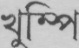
খুম্পি
